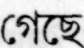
গেছে
